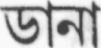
ডানা
